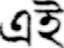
এই
